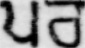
ਪਰ
